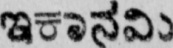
ಇಕಾನಮಿ
